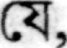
যে,
